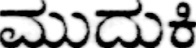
ಮುದುಕಿ
